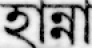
হান্না
